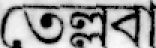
তেল্লবা
